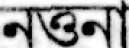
নত্তনা
